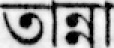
তান্না
